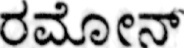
ರಮೋನ್
